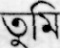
তুমি
